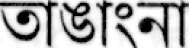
তাঙাংনা
